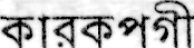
কারকপগী
